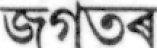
জগতৰ
